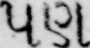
પણ
